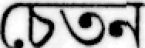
চেতন
